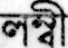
লম্বী
